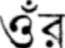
ওঁর
